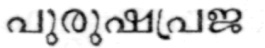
പുരുഷപ്രജ
